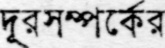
দূরসম্পর্কের
